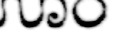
ಊರ
